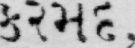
કરમદ.
